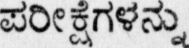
ಪರೀಕ್ಷೆಗಳನ್ನು
